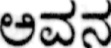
ಅವನ
